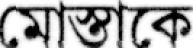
মোস্তাকে
